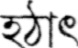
হঠাত্
